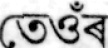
তেওঁৰ
